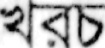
খরচ
